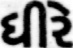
ધીરે
